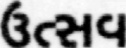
ઉત્સવ
